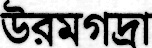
উরমগদ্রা
